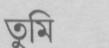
তুমি
